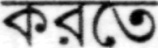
করতে
